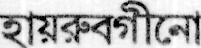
হায়রুবগীনো
